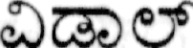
ವಿಡಾಲ್
